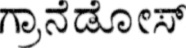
ಗ್ರಾನೆಡೋಸ್
